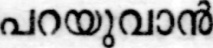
പറയുവാന്‍
